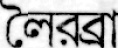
লৈরব্রা
